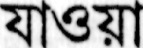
যাওয়া
